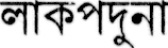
লাকপদুনা
